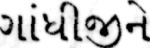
ગાંધીજીને
